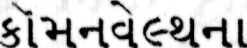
કૉમનવેલ્થના
